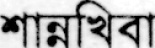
শান্নখিবা
